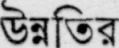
উন্নতির
